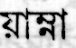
য়াম্না
